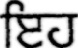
ਇਹ
